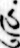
હું
